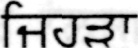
ਜਿਹੜਾ
